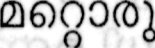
മറ്റൊരു
